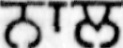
ਨਾਲ
